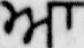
ਆ
